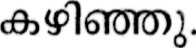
കഴിഞ്ഞു.
